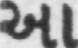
આ
